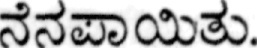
ನೆನಪಾಯಿತು.
